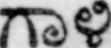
ಗಾಳಿ
